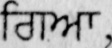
ਗਿਆ,
